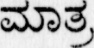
ಮಾತ್ರ
